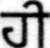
ਹੀ
